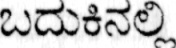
ಬದುಕಿನಲ್ಲಿ
